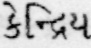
કેન્દ્રિય
